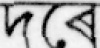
দৰে
